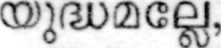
യുദ്ധമല്ലേ,
